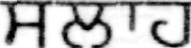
ਸਲਾਹ
